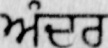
ਅੰਦਰ
